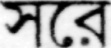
সরে
